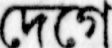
দেগে
